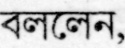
বললেন,
